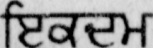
ਇਕਦਮ
